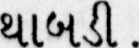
થાબડી.
